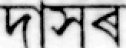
দাসৰ
